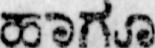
ಹಾಗೂ
